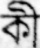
কী
